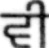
ਵੀ
